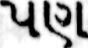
પણ
